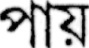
পায়
